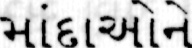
માંદાઓને
